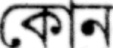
কোন
